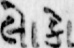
લોકો
